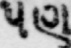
પણ
